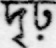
দৃঢ়
